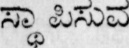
ಸ್ಥಾಪಿಸುವ
